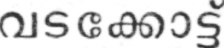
വടക്കോട്ട്
